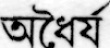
অধৈর্য
